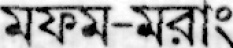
মফম-মরাং
